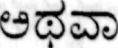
ಅಥವಾ
